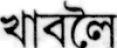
খাবলৈ
